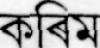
কৰিম
